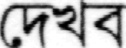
দেখব
